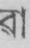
ৱা
